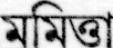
মমিত্তা
